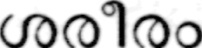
ശരീരം
